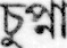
চুপ্না
